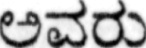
ಅವರು
